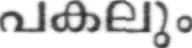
പകലും
